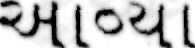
આવ્યા
